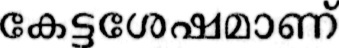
കേട്ടശേഷമാണ്
